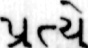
પ્રત્યે
